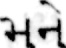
મને
